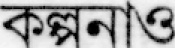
কল্পনাও
